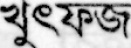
খুৎফজ
